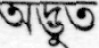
অদ্ভুত
